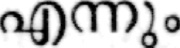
എന്നും
